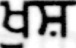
ਖੁਸ਼
